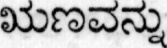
ಋಣವನ್ನು
